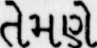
તેમણે
